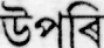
উপৰি
